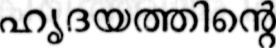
ഹൃദയത്തിന്റെ
